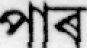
পাৰ
